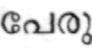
പേരു
